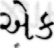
એક
